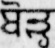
ਬੋੜ੍ਹ
